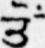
ਤੋਂ
